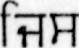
ਜਿਸ
